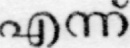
എന്ന്
